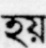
হয়
